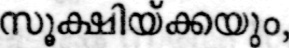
സൂക്ഷിയ്ക്കയും,
